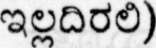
ಇಲ್ಲದಿರಲಿ)
